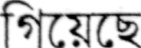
গিয়েছে
